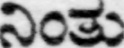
ನಿಂತು
